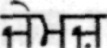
ਜੇਮਜ਼
